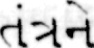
તંત્રને
